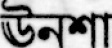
ঊনশা
